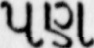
પણ
